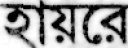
হায়রে
